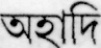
অহাদি
